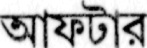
আফটার
